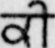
ਕੀ
